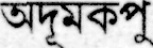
অদূমকপু
